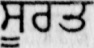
ਸੂਰਤ
